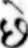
છે
